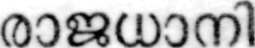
രാജധാനി
